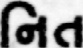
નિત
